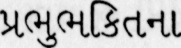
પ્રભુભક્તિના
